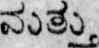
ಮತ್ತು
